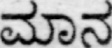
ಮಾನ
